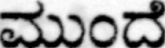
ಮುಂದೆ
